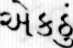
એકઠું
